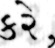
કરે,
